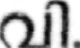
വി.
